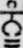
ਨੂੰ
